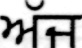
ਅੱਜ
